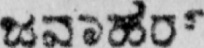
ಜವಾಹರ್
